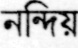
নন্দিয়
